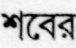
শবের
